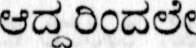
ಆದ್ದರಿಂದಲೇ
